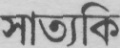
সাত্যকি
